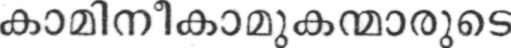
കാമനീകാമുകന്മാരുടെ
